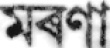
মৰণা
